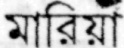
মারিয়া
